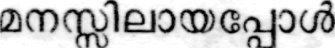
മനസ്സിലായപ്പോള്‍
